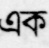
এক
